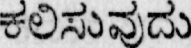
ಕಲಿಸುವುದು
